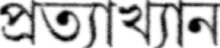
প্রত্যাখ্যান
